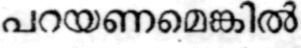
പറയണമെങ്കില്‍
